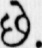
છે.
